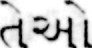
તેઓ
